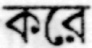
করে
